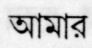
আমার
